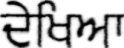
ਦੇਖਿਆ
